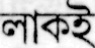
লাকই
